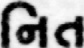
નિત
